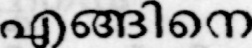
എങ്ങിനെ
